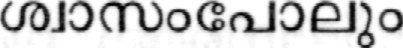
ശ്വാസംപോലും
